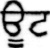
ਊਟ
